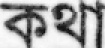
কথা
